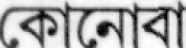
কোনোবা
